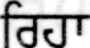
ਰਿਹਾ
